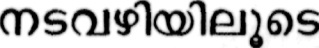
നടവഴിയിലൂടെ
